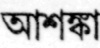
আশঙ্কা
